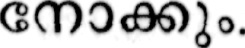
നോക്കും,
